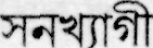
সনখ্যাগী
